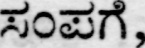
ಸಂಪಗೆ,
